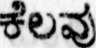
ಕೆಲವು
